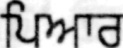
ਪਿਆਰ
